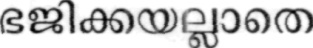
ഭജിക്കയല്ലാതെ
